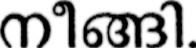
നീങ്ങി.
